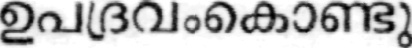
ഉപദ്രവംകൊണ്ടു
